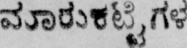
ಮಾರುಕಟ್ಟೆಗಳ
